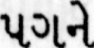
પગને
